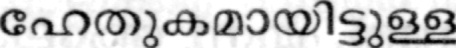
ഹേതുകമായിട്ടുള്ള
